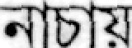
নাচায়
